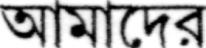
আমাদের
